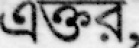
এক্তর,
